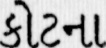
કોટના
